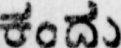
ಕಂದು
